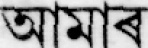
আমাৰ
